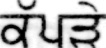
ਕੱਪੜੇ
